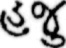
હજુ
